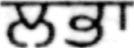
ਲਭਾ
